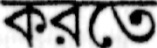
করতে
